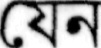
যেন
